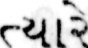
ત્યારે
